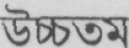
উচ্চতম
